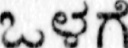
ಒಳಗೆ
